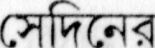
সেদিনের
